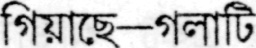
গিয়াছে—গলাটি
